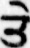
ਤੇ
